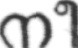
നീ
